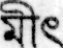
মীৎ
